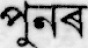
পুনৰ
